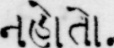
નહોતો.
